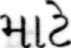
માટે
